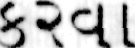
કરવા
